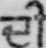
ਦੀ
